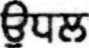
ਉਧਲ
